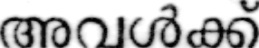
അവള്‍ക്ക്
